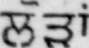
ਲੋੜਾਂ
